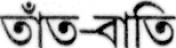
তাঁত-বাতি
